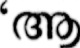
‘ആ
